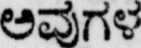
ಅವುಗಳ
